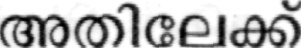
അതിലേക്ക്
